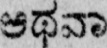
ಅಥವಾ
